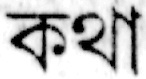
কথা
